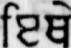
ਇਥੇ
